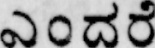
ಎಂದರೆ
